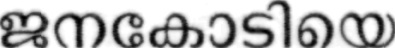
ജനകോടിയെ
